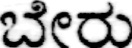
ಬೇರು
